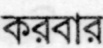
করবার
